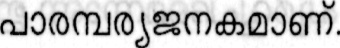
പാരമ്പര്യജനകമാണ്.
